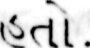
હતો.
